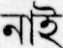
নাই
